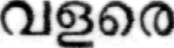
വളരെ
